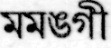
মমঙগী
